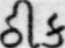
ઠીક
